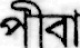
পীবা
